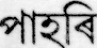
পাহৰি
